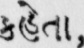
કહેતા,
